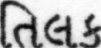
તિલક
